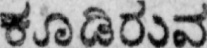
ಕೂಡಿರುವ
